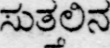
ಸುತ್ತಲಿನ
